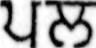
ਪਲ
